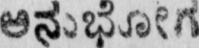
ಅನುಭೋಗ
